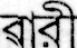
ৱারী
